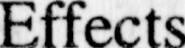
Effects
